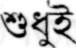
শুধুই
